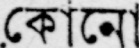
কোনো
